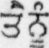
ਤੈਨੂੰ
